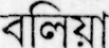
বলিয়া
